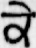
ਕੇ
